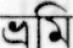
ভ্রমি
